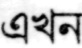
এখন
